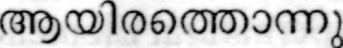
ആയിരത്തൊന്നു
